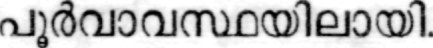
പൂര്‍വാവസ്ഥയിലായി.
